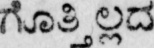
ಗೊತ್ತಿಲ್ಲದ
